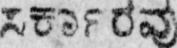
ಸರ್ಕಾರವು
